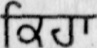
ਕਿਹਾ
